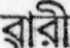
ৱারী
